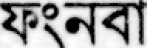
ফংনবা
